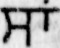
ਸਾਂ
